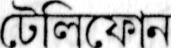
টেলিফোন
